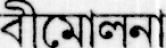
বীমোলনা
